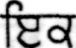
ਇਕ
